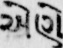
એણે
